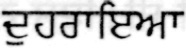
ਦੁਹਰਾਇਆ
